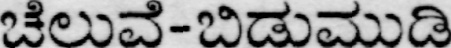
ಚೆಲುವೆ-ಬಿಡುಮುಡಿ
